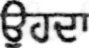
ਉਹਦਾ
